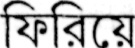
ফিরিয়ে
